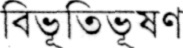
বিভূতিভূষণ
